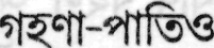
গহণা-পাতিও
